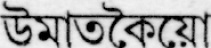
উমাতকৈয়ো
